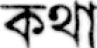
কথা
